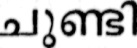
ചുണ്ടി
